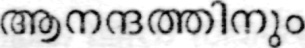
ആനന്ദത്തിനും
